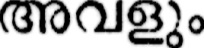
അവളും
